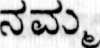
ನಮ್ಮ
